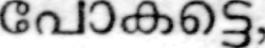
പോകട്ടെ,
